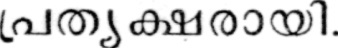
പ്രത്യക്ഷരായി.
